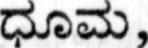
ಧೂಮ,
